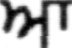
ਆ
